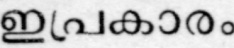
ഇപ്രകാരം
